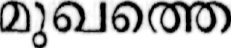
മുഖത്തെ
